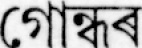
গোন্ধৰ
